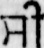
ਸੀ
